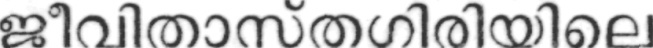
ജീവിതാസ്തഗിരിയിലെ
